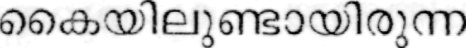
കൈയിലുണ്ടായിരുന്ന
